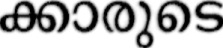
ക്കാരുടെ
